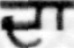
ਦਾ
